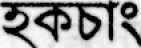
হকচাং
